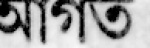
আগত
